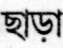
ছাড়া
